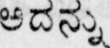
ಅದನ್ನು
